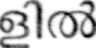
ളില്‍
